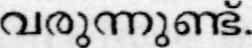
വരുന്നുണ്ട്.
